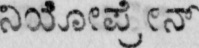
ನಿಯೋಪ್ರೇನ್
